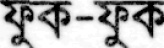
ফুক-ফুক
